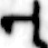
ન
